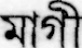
মাগী
